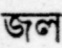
জল
